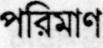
পরিমাণ
